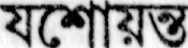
যশোয়ন্ত
